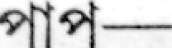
পাপ-
